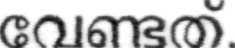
വേണ്ടത്.
